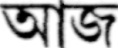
আজ
